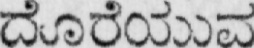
ದೊರೆಯುವ
